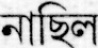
নাছিল
